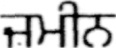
ਜ਼ਮੀਨ
